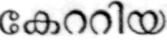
കേററിയ
